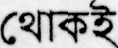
থোকই
